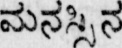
ಮನಸ್ಸಿನ
